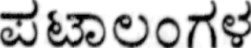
ಪಟಾಲಂಗಳ
